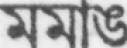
মমাঙ
